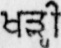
ਖੜ੍ਹੀ
